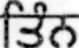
ਤਿੰਨ
